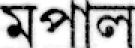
মপাল
